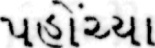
પહોંચ્યા
